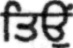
ਤਿਉਂ
